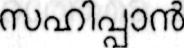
സഹിപ്പാന്‍
